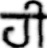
ਹੀ
